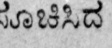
ಸೂಚಿಸಿದ
